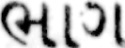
ભાગ
